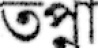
তপ্না
